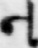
ન
